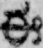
ಈ
